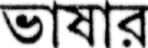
ভাষার
